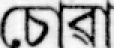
চোৱা
